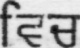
ਵਿਚ
